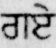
ਗਏ
